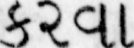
કરવા
